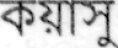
কয়াসু
